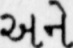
અને
